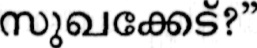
സുഖക്കേട്?”
